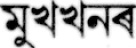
মুখখনৰ
